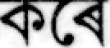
কৰে
